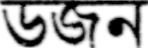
ডজন
